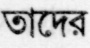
তাদের
